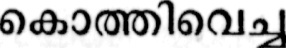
കൊത്തിവെച്ച
